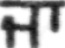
ਜਾ
